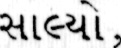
સાલ્યો,
